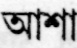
আশা
